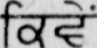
ਕਿਵੇਂ
